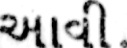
આવી.
